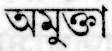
অমুক্তা
